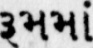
રૂમમાં
